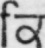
ਕਿ
